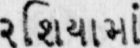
રશિયામાં
